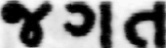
જગત
